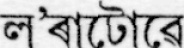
ল'ৰাটোৱে
